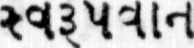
સ્વરૂપવાન
